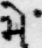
મેં
